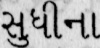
સુધીના
